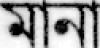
মানা
